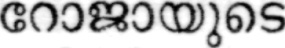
റോജായുടെ
